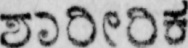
ಶಾರೀರಿಕ
